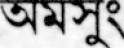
অমসুং
